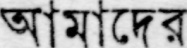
আমাদের
